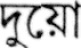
দুয়ো
